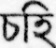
চহি
